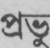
প্ৰভু
